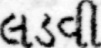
લડવી
